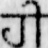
ਹੀ
